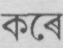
কৰে
